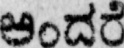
ಅಂದರೆ
